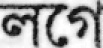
লগে
